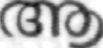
ആ
